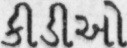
કીડીઓ
